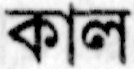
কাল
